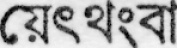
য়েংথংবা
